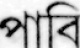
পাবি
